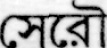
সেরৌ
